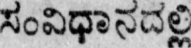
ಸಂವಿಧಾನದಲ್ಲಿ
